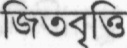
জিতবৃত্তি
